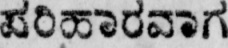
ಪರಿಹಾರವಾಗ
